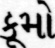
કૂમો
